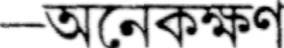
-অনেকক্ষণ
